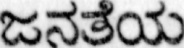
ಜನತೆಯ
